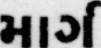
માર્ગ
